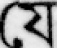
যে
